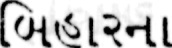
બિહારના
